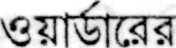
ওয়ার্ডারের
